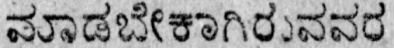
ಮಾಡಬೇಕಾಗಿರುವವರ
